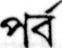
পর্ব
